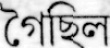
গৈছিল
